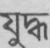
যুদ্ধ
